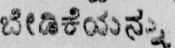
ಬೇಡಿಕೆಯನ್ನು
